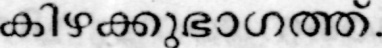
കിഴക്കുഭാഗത്ത്.
